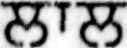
ਲਾਲ
